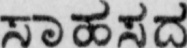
ಸಾಹಸದ
